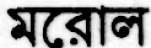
মরোল
